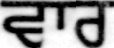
ਵਾਰ
